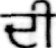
ਦੀ
